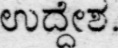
ಉದ್ದೇಶ.
